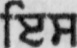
ਇਸ
